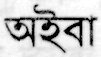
অইবা
